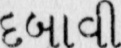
દબાવી
